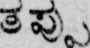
ತಪ್ಪು
